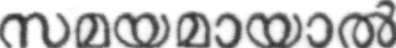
സമയമായാല്‍
